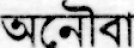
অনৌবা
